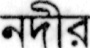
নদীর
